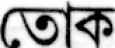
তোক
